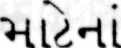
માટેનાં
